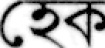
হেক
